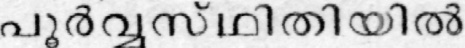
പൂര്‍വ്വസ്ഥിതിയില്‍
